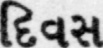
દિવસ
